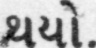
થયો.
